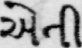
એની
